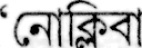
‘নোক্লিবা
